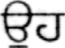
ਉਹ
